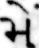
મેં
